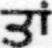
ਤਾਂ
